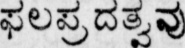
ಫಲಪ್ರದತ್ವವು
